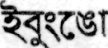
ইবুংঙো
